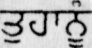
ਤੁਹਾਨੂੰ
